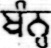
ਬੰਨ੍ਹ
